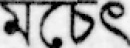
মচেৎ
